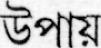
উপায়
